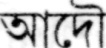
আদৌ
